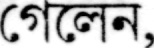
গেলেন,
